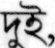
দুই,
